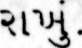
રાખું.
